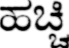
ಹಚ್ಚಿ
